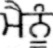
ਮੈਨੂੰ
